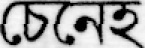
চেনেহ
